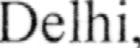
Delhi,
